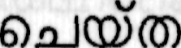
ചെയ്ത
